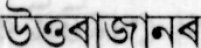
উত্তৰাজানৰ
